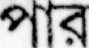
পার
